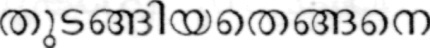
തുടങ്ങിയതെങ്ങനെ
